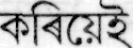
কৰিয়েই
